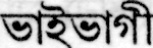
ভাইভাগী
